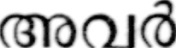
അവര്‍
